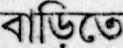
বাড়িতে
